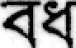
বধ
